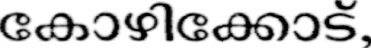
കോഴിക്കോട്,
